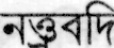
নত্ত্রবদি
